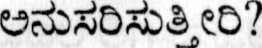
ಅನುಸರಿಸುತ್ತೀರಿ?
